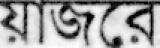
য়াজরে
